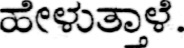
ಹೇಳುತ್ತಾಳೆ.
